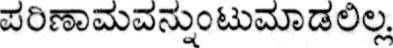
ಪರಿಣಾಮವನ್ನುಂಟುಮಾಡಲಿಲ್ಲ
